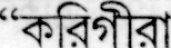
“করিগীরা
